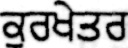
ਕੁਰਖੇਤਰ
